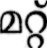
മറ്റ്
